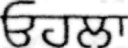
ਓਹਲਾ
